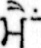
ਮੈਂ
